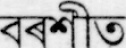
বৰশীত
